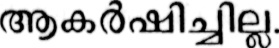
ആകര്‍ഷിച്ചില്ല.
